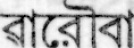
ৱারৌবা
